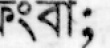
ফংবা;
